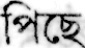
পিছে
